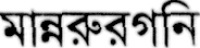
মান্নরুরগনি
